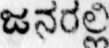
ಜನರಲ್ಲಿ
